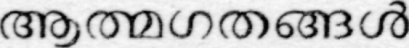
ആത്മഗതങ്ങള്‍
